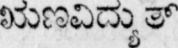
ಋಣವಿದ್ಯುತ್
